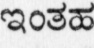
ಇಂತಹ
